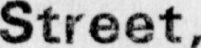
Street,
